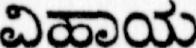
ವಿಹಾಯ
